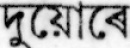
দুয়োৰে
